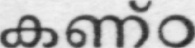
കണ്ഠ
